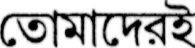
তোমাদেরই
